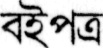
বইপত্র
